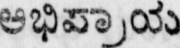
ಅಭಿಪ್ರಾಯ
